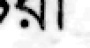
চরা
